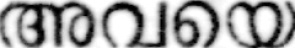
അവയെ
